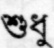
শুধু
